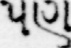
પણ
